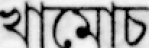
খামোচ
